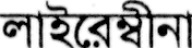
লাইরেম্বীনা
